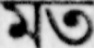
মত
